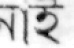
নাই
